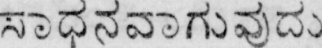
ಸಾಧನವಾಗುವುದು
